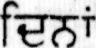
ਦਿਨਾਂ
